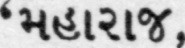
'મહારાજ,
